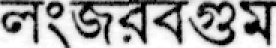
লংজরবগুম
